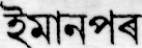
ইমানপৰ
